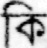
কি
